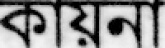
কায়না
